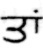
ਤਾਂ
